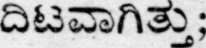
ದಿಟವಾಗಿತ್ತು;
